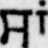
ਸਾਂ
